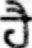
ਹੈ
